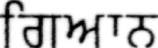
ਗਿਆਨ
